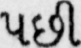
પછી
